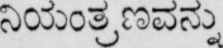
ನಿಯಂತ್ರಣವನ್ನು
